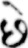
છે
